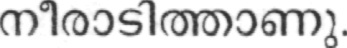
നീരാടിത്താണു.
